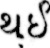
થઈ
